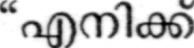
“എനിക്ക്
